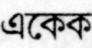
একেক
